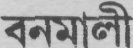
বনমালী
